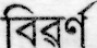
বিৱর্ণ
